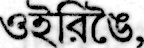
ওইরিঙৈ,
